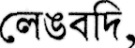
লেঙবদি,
